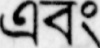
এবং
